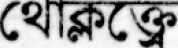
থোক্লক্ত্রে
